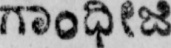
ಗಾಂಧೀಜಿ
